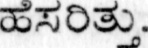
ಹೆಸರಿತ್ತು.
